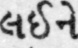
લઈને
